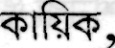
কায়িক,
